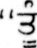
''ਤੂੰ
